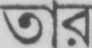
তার
